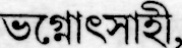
ভগ্নোৎসাহী,
